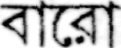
বারো
